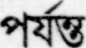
পর্যন্ত
